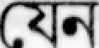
যেন
